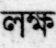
লক্ষ
